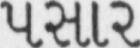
પસાર
